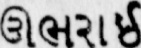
ઊભરાઈ
